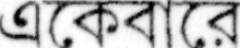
একেবারে
